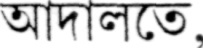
আদালতে,
